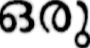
ഒരു
